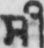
ਸੀ
